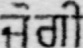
ਜੋਗੀ
